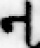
ન
